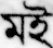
মই
